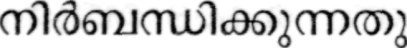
നിര്‍ബന്ധിക്കുന്നതു
